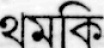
থমকি
